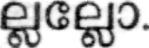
ല്ലല്ലോ.
